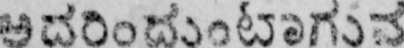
ಅದರಿಂದುಂಟಾಗುವ
